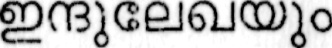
ഇന്ദുലേഖയും
